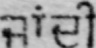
ਜਾਂਦੀ
